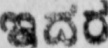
ಇದರ
